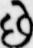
છે
